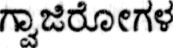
ಗ್ವಾಜಿರೋಗಳ
